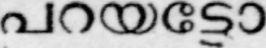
പറയട്ടോ
